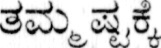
ತಮ್ಮಷ್ಟಕ್ಕೆ
